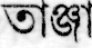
তাঞ্জা
